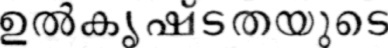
ഉല്‍കൃഷ്ടതയുടെ
